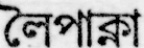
লৈপাক্না
